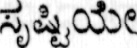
ಸೃಷ್ಟಿಯೇ
